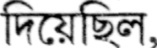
দিয়েছিল,
